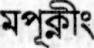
মপূক্নীং
